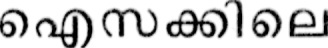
ഐസക്കിലെ
